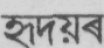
হৃদয়ৰ
